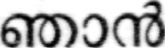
ഞാന്‍
